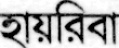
হায়রিবা
